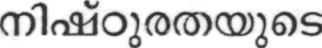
നിഷ്ഠുരതയുടെ
